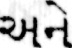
અને
